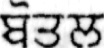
ਬੋਤਲ
